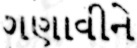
ગણાવીને
